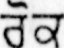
ਰੋਕ
